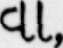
વા,
